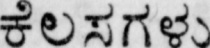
ಕೆಲಸಗಳು
